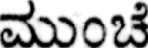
ಮುಂಚೆ
